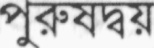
পুরুষদ্বয়
